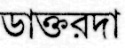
ডাক্তরদা
